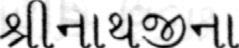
શ્રીનાથજીના
